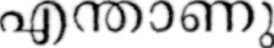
എന്താണു
